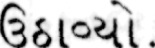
ઉઠાવ્યો.
